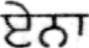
ਏਨਾ
